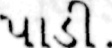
પાડી.
